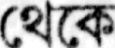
থেকে
